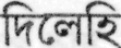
দিলেহি
